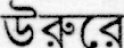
উরুরে
